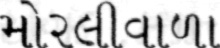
મોરલીવાળા
